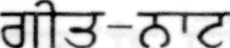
ਗੀਤ-ਨਾਟ
